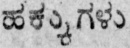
ಹಕ್ಕುಗಳು
